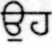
ਉਹ
